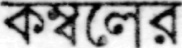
কম্বলের
